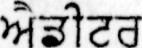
ਐਡੀਟਰ
